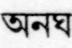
অনঘ
